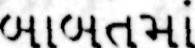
બાબતમાં
